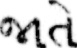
જાતે
